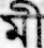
মী
